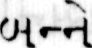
બન્ને
